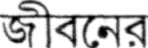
জীবনের
